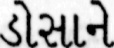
ડોસાને
